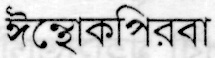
ঈন্থোকপিরবা
